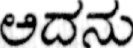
ಅದನು
